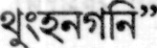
থুংহনগনি”
